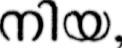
നിയ,
